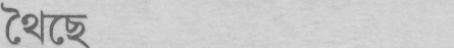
থৈছে
